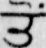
ਤੋਂ
